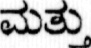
ಮತ್ತು
